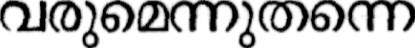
വരുമെന്നുതന്നെ
